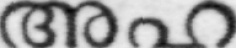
അഹ
